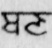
ਬਣ
